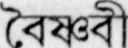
বৈষ্ণবী
